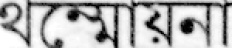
থম্মোয়না
